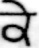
ਕੇ
